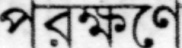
পরক্ষণে
